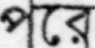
পরে
